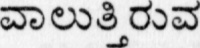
ವಾಲುತ್ತಿರುವ
